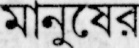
মানুষের
